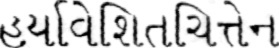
હર્યાવેશિતચિત્તેન
